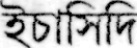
ইচাসিদি
